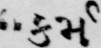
“કર્મ
